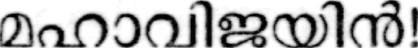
മഹാവിജയിന്‍!
